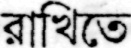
রাখিতে
